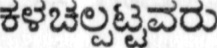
ಕಳಚಲ್ಪಟ್ಟವರು
